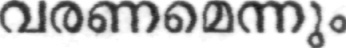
വരണമെന്നും
